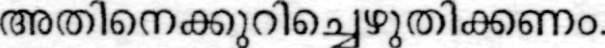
അതിനെക്കുറിച്ചെഴുതിക്കണം.
